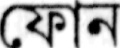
ফোন
